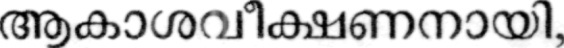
ആകാശവീക്ഷണനായി,
